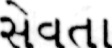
સેવતા
